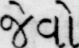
જેવો
